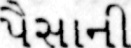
પૈસાની
